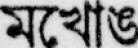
মখোঙ
